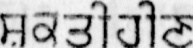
ਸ਼ਕਤੀਹੀਣ
